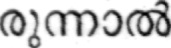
രുന്നാല്‍
